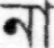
না
